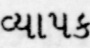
વ્યાપક
